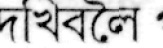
দেখিবলৈ
